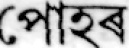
পোহৰ
